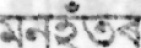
মনহঁতৰ
